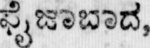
ಫೈಜಾಬಾದ,
